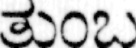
ತುಂಬ
